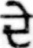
ਦੇ
